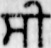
ਸੀ
